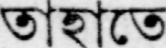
তাহাতে
